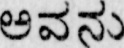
ಅವನು
